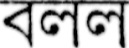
বলল
